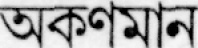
অকণমান
